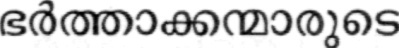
ഭര്‍ത്താക്കന്മാരുടെ
